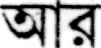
আর
